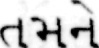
તમને
